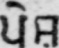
ਪੇਸ਼
